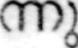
ന്നു
